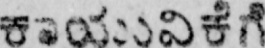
ಕಾಯುವಿಕೆಗೆ
